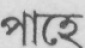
পাহে
